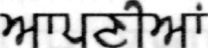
ਆਪਣੀਆਂ
